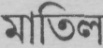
মাতিল
